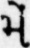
મેં
